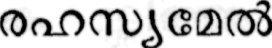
രഹസ്യമേല്‍
